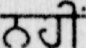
ਨਹੀਂ
